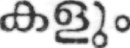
കളും
